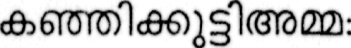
കഞ്ഞിക്കുട്ടിഅമ്മ:
